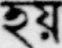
হয়
